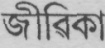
জীৱিকা
